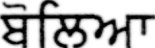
ਬੋਲਿਆ
